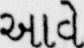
આવે
